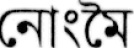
নোংমৈ
